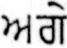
ਅਗੇ
